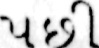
પછી
